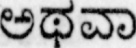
ಅಥವಾ
